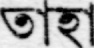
তাহা
